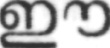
ഈ
